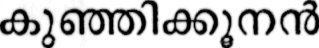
കുഞ്ഞിക്കൂനന്‍
